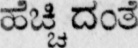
ಹೆಚ್ಚಿದಂತೆ
